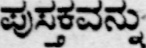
ಪುಸ್ತಕವನ್ನು
